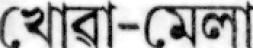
খোৱা-মেলা
